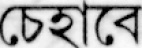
চেহাবে
